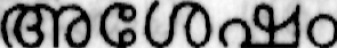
അശേഷം
